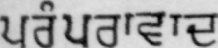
ਪਰੰਪਰਾਵਾਦ
